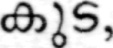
കുട,
